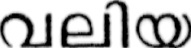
വലിയ
